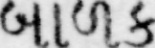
બાળક
